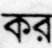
কর
